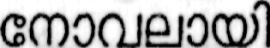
നോവലായി
